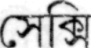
সেক্সি
